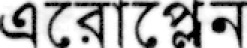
এরোপ্লেন
